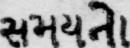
સમયનો
